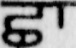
ਛਾ
